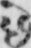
છે
